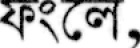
ফংলে,
